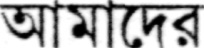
আমাদের
